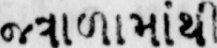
જ્વાળામાંથી
